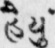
હૈયું
